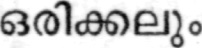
ഒരിക്കലും
